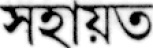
সহায়ত
